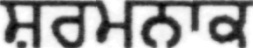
ਸ਼ਰਮਨਾਕ
